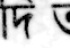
দি
